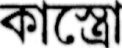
কাস্ত্রো
